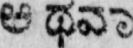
ಅಥವಾ
